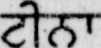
ਟੀਨਾ
